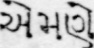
એમણે
